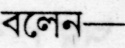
বলেন–
